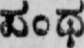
ಪಂಥ
